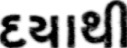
દયાથી
